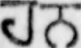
ਹਨ
